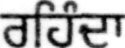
ਰਹਿੰਦਾ
